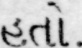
હતો.
